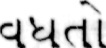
વધતો
